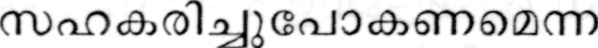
സഹകരിച്ചുപോകണമെന്ന
